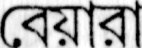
বেয়ারা
